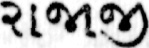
રાજાજી
